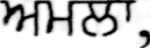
ਅਮਲਾ,
